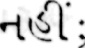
નહીં;
